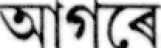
আগৰে
